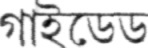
গাইডেড
